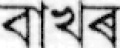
বাখৰ
